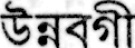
উন্নবগী
